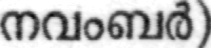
നവംബര്‍)
